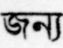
জন্য
